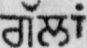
ਗੱਲਾਂ
